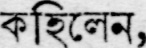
কহিলেন,
